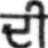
ਦੀ
